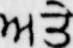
ਅਤੇ
